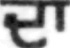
ਦਾ
